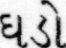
ઘડો
